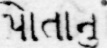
પોતાનું
